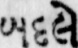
બદલે
